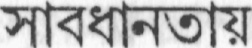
সাবধানতায়
